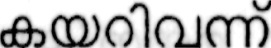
കയറിവന്ന്
